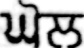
ਘੋਲ
